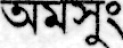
অমসুং
